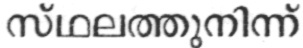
സ്ഥലത്തുനിന്ന്
